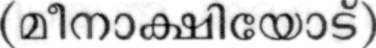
(മീനാക്ഷിയോട്)
